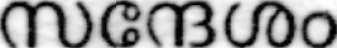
സന്ദേശം
